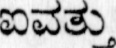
ಐವತ್ತು
